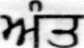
ਅੰਤ
